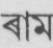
ৰাম
